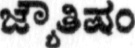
ಜ್ಯೌತಿಷಂ
